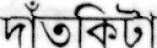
দাঁতকিটা
